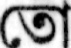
তো
